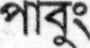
পাবুং
